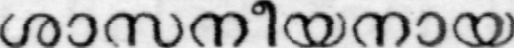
ശാസനീയനായ
